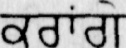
ਕਰਾਂਗੇ
